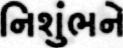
નિશુંભને
